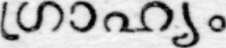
ഗ്രാഹ്യം
